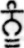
ਨੂੰ
